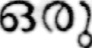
ഒരു
